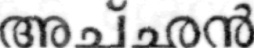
അച്ഛന്‍
